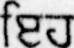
ਇਹ
